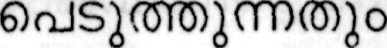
പെടുത്തുന്നതും
